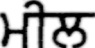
ਮੀਲ
